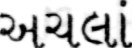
અચલાં
